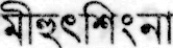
মীহুৎশিংনা
